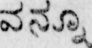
ವನ್ನೂ
